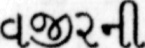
વજીરની
